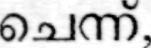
ചെന്ന്,
